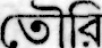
তৌরি
